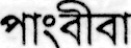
পাংবীবা
